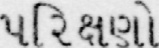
પરિક્ષણો
